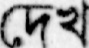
দেখ
